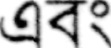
এবং
